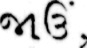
જાઉં,
